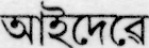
আইদেৱে
